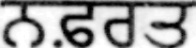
ਨਫ਼ਰਤ
